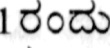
1ರಂದು
